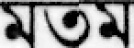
মতম
